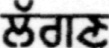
ਲੱਗਣ
